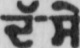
ਦੱਸੇ
